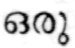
ഒരു
